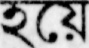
হয়ে
